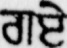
ਗਏ
